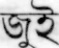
জুই
